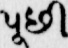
પૂછી
